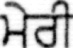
ਮੇਰੀ
